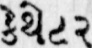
કેથેટર
